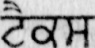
ਟੈਕਸ
